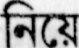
নিয়ে
